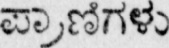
ಪ್ರಾಣಿಗಳು
